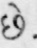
છે.
